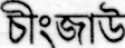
চীংজাউ
